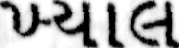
ખ્યાલ
